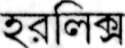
হরলিক্স
